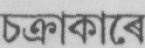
চক্ৰাকাৰে
